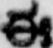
ಈ
